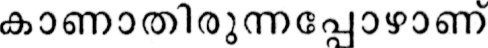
കാണാതിരുന്നപ്പോഴാണ്
